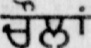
ਚੌਲਾਂ
